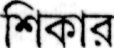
শিকার
